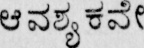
ಆವಶ್ಯಕವೇ
